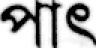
পাৎ
